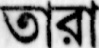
তারা
